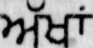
ਅੱਖਾਂ
